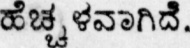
ಹೆಚ್ಚಳವಾಗಿದೆ.
